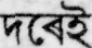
দৰেই
